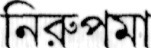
নিরুপমা
